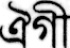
ঐগী
